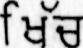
ਖਿੱਚ
